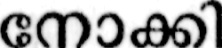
നോക്കി
